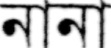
নানা
